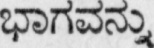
ಭಾಗವನ್ನು
